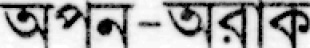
অপন-অরাক
